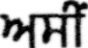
ਅਸੀਂ
